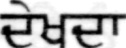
ਦੇਖਦਾ
